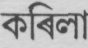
কৰিলা
